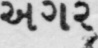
અગર
